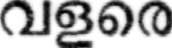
വളരെ
